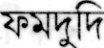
ফমদুদি
